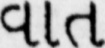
વાત
